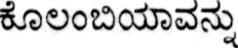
ಕೊಲಂಬಿಯಾವನ್ನು
